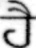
ਹੈ
